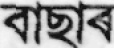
বাছাৰ
